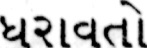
ધરાવતો
